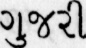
ગુજરી
